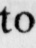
To
